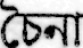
চৈনা
